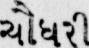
ચૌધરી
